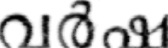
വര്‍ഷ
